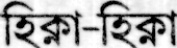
হিক্না-হি্ক্না
